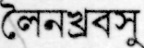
লৈনখ্রবসু
